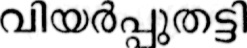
വിയര്‍പ്പുതട്ടി
